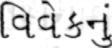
વિવેકનું
